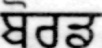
ਬੋਰਡ
